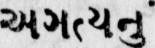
અગત્યનું
